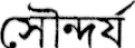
সৌন্দর্য
